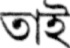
তাই
